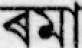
ৰমা
